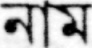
নাম
